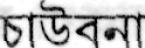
চাউবনা
